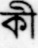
কী
